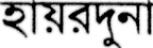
হায়রদুনা
